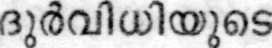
ദുര്‍വിധിയുടെ
